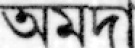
অমদা
